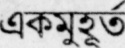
একমুহূর্ত
